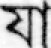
যা
